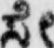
ಸೇ
